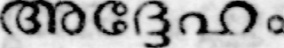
അദ്ദേഹം
